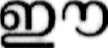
ഈ
